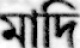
মাদি
